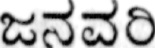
ಜನವರಿ
